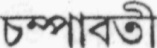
চম্পাবতী
